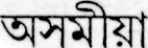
অসমীয়া
